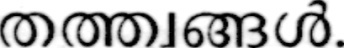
തത്ത്വങ്ങള്‍.
